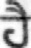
ਹੈ
